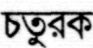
চতুরক
